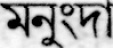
মনুংদা
